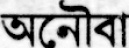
অনৌবা
